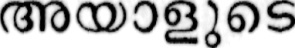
അയാളുടെ
